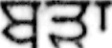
ਬੜਾ
